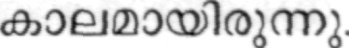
കാലമായിരുന്നു.
